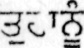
ਤੁਹਾਨੂੰ
